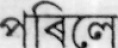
পৰিলে
